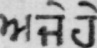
ਅਜੇਹੇ
